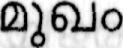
മുഖം
